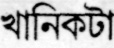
খানিকটা
